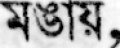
মঙায়,
